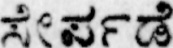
ಸೇರ್ಪಡೆ
